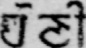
ਹੋਣੀ
